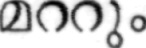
മററും
